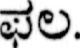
ಫಲ.
